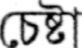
চেষ্টা
